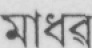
মাধৱ
